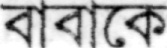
বাবাকে
